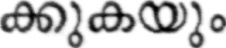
ക്കുകയും
